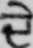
ਦੇ
